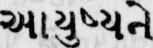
આયુષ્યને
